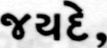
જયદે,
